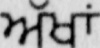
ਅੱਖਾਂ
